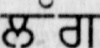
ਲੱਗ
